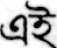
এই
